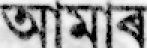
আমাৰ
